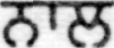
ਨਾਲ
